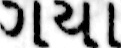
ગયા
